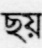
ছয়
